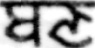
ਬਣ
